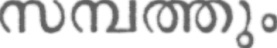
സമ്പത്തും
